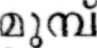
മുമ്പ്
